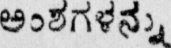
ಅಂಶಗಳನ್ನು
